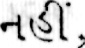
નહીં,
